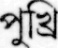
পুখ্রি
